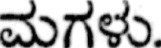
ಮಗಳು.
